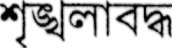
শৃঙ্খলাবদ্ধ
